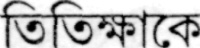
তিতিক্ষাকে
